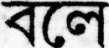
বলে
